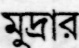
মুদ্রার
